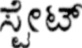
ಸ್ಪೇಟ್
